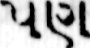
પણ
